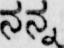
ನನ್ನ
